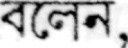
বলেন,
